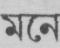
মনে
